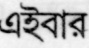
এইবার
